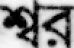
শ্বর
